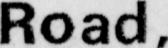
Road,
